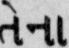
તેના
